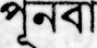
পূনবা
